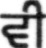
ਵੀ
